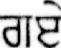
ਗਏ
